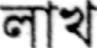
লাখ
